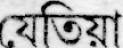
যেতিয়া
